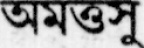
অমত্তসু
